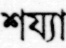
শয্যা
